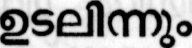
ഉടലിന്നും
